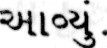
આવ્યું.
